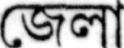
জেলা
